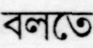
বলতে
